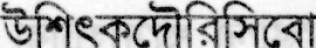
উশিৎকদৌরিবসিবো
